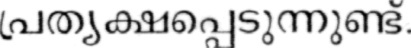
പ്രത്യക്ഷപ്പെടുന്നുണ്ട്.
